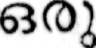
ഒരു
